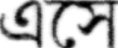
এসে
